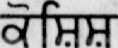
ਕੋਸ਼ਿਸ਼
